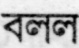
বলল
